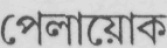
পেলায়োক
